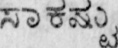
ಸಾಕಷ್ಟು
